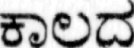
ಕಾಲದ
